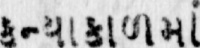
કન્યાકાળમાં
